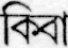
কিবা
